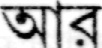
আর
